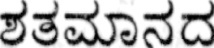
ಶತಮಾನದ
